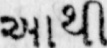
આથી
